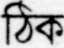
ঠিক
